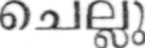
ചെല്ലു
